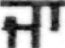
ਜਾ
